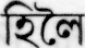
হিলৈ
